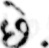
છે.
